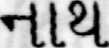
નાથ
